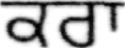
ਕਰਾ
